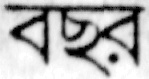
বছর
